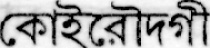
কোইরৌদগী
